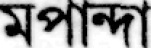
মপান্দা
